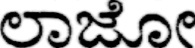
ಲಾಜೋ
